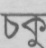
চকু
